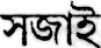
সজাই
